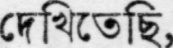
দেখিতেছি,
